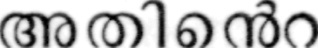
അതിന്റെ
